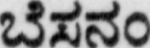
ಬೆಸನಂ
